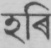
হৰি
